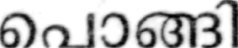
പൊങ്ങി
